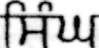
ਸਿੰਘ
